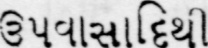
ઉપવાસાદિથી
